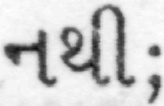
નથી;
